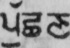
ਪੁੱਛਣ
